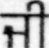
ਜੀ
